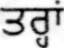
ਤਰ੍ਹਾਂ
